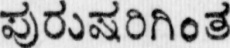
ಪುರುಷರಿಗಿಂತ
